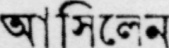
আসিলেন
